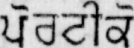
ਪੋਰਟੀਕੋ
